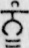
ਨੂੰ
